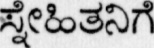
ಸ್ನೇಹಿತನಿಗೆ
